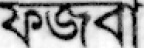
ফজবা
